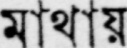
মাথায়
